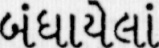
બંધાયેલાં
